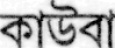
কাউবা
